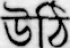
উঠি
